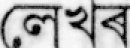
লেখৰ
